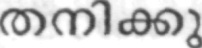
തനിക്കു
